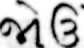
જોઉં
